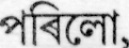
পৰিলো,
